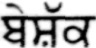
ਬੇਸ਼ੱਕ
